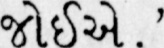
જોઈએ.'
